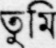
তুমি
